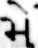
મેં
